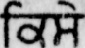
ਕਿਸੇ
